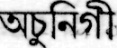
অচুনিগী
